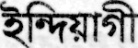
ইন্দিয়াগী
